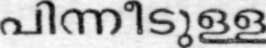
പിന്നീടുള്ള
